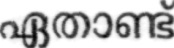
ഏതാണ്ട്
